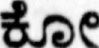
ಕೋ
